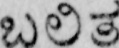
ಬಲಿತ
